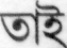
তাই
